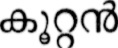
കൂറ്റന്‍
